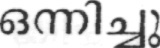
ഒന്നിച്ചു
